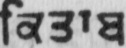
ਕਿਤਾਬ
